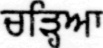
ਚੜ੍ਹਿਆ
